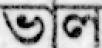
ভাল
